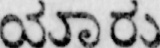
ಯಾರು
